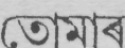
তোমাৰ
